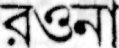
রওনা
